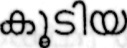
കൂടിയ
